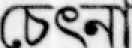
চেৎনা
